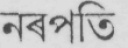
নৰপতি
